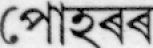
পোহৰৰ
